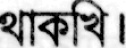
থোকখি
